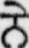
ਨੇ
